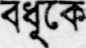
বধূকে
